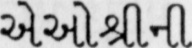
એઓશ્રીની
